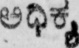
ಅಧಿಕ್ಯ
